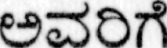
ಅವರಿಗೆ
